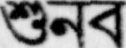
শুনব
